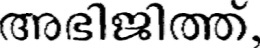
അഭിജിത്ത്,
